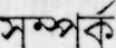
সম্পর্ক
